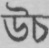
উচ
